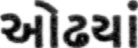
ઓઢ્યાં
